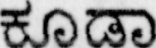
ಕೂಡಾ
